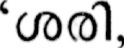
‘ശരി,
